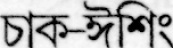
চাক-ঈশিং
